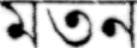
মতন
